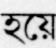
হয়ে
